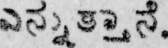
ಎನ್ನುತ್ತಾನೆ.
